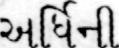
અર્ધિની
